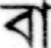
বা
